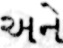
અને
